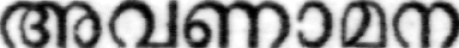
അവണാമന
